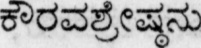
ಕೌರವಶ್ರೇಷ್ಠನು
